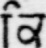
ਕਿ
